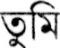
তুমি
